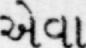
એવા
